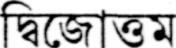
দ্বিজোত্তম
